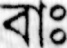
বাঃ
